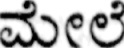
ಮೇಲೆ
